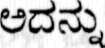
ಅದನ್ನು
